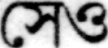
সেও
